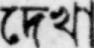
দেখা
